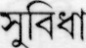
সুবিধা
